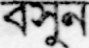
বসুন
